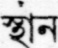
স্থান
